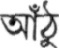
আঁঠু
